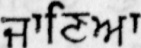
ਜਾਣਿਆ
